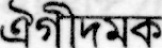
ঐগীদমক
